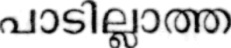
പാടില്ലാത്ത
